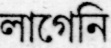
লাগেনি
